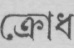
ক্ৰোধ
